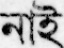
নাই
